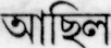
আছিল
